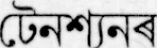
টেনশ্যনৰ
